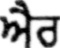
ਐਰ
